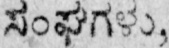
ಸಂಘಗಳು,
